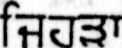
ਜਿਹੜਾ
